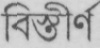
বিস্তীৰ্ণ
